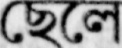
ছেলে
